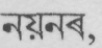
নয়নৰ,
